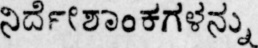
ನಿರ್ದೇಶಾಂಕಗಳನ್ನು
